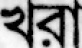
খরা
